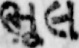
ભૂલ
